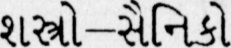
શસ્ત્રો-સૈનિકો
